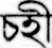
চহী
